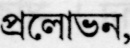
প্রলোভন,
